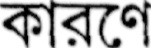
কারণে
